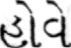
હોવે
